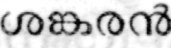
ശങ്കരന്‍
